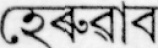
হেৰুৱাব
